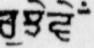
ਰੁਝੇਵੇਂ
